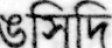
ঙসিদি
